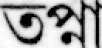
তপ্না
